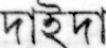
দাইদা
